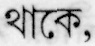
থাকে,
